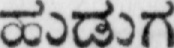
ಹುಡುಗ
